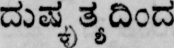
ದುಷ್ಕೃತ್ಯದಿಂದ
